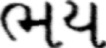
ભય
